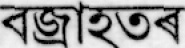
বজ্ৰাহতৰ
